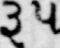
રૂપ
